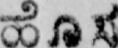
ಹೊಸ
